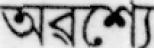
অৱশ্যে
